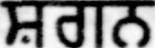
ਸ਼ਗਨ
